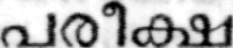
പരീക്ഷ
